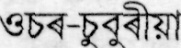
ওচৰ-চুবুৰীয়া
